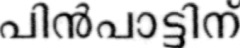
പിന്‍പാട്ടിന്
